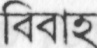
বিবাহ
